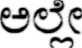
ಅಲ್ಲೇ
